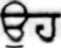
ਉਹ
